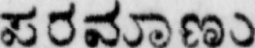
ಪರಮಾಣು
